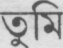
তুমি
